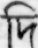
দি
